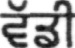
ਵੱਡੀ
